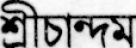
শ্রীচান্দম
